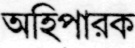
অহিপারক
